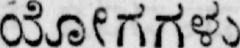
ಯೋಗಗಳು
